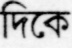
দিকে
